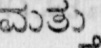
ಮತ್ತು
